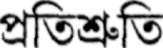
প্রতিশ্রুতি
